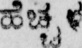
ಹೆಚ್ಚಳ
